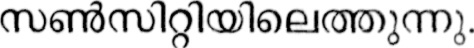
സണ്‍സിറ്റിയിലെത്തുന്നു.
